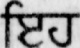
ਇਹ
